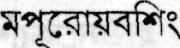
মপূরোয়বশিং
